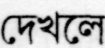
দেখলে
